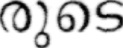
രുടെ
